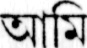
আমি
